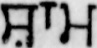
ਸ਼ਾਮ
